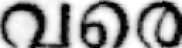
വരെ
